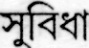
সুবিধা
